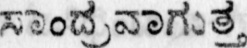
ಸಾಂದ್ರವಾಗುತ್ತ
